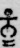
ਨੂੰ
